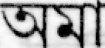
অমা
